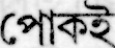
পোকই
